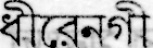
ধীরেনগী
